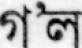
গ'ল
